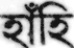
হাঁহি
